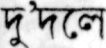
দু'দলে
